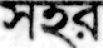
সহর
